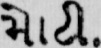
મોટી.
